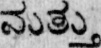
ಮತ್ತು
